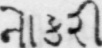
નોકરી
